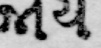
જાય
